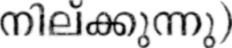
നില്ക്കുന്നു)
